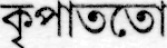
কৃপাততো
